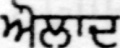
ਔਲਾਦ
